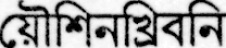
য়ৌশিনখ্রিবনি
